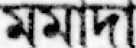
মমাদা
